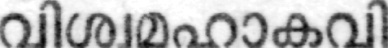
വിശ്വമഹാകവി
